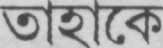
তাহাকে
